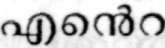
എന്റെ
